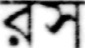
রস
